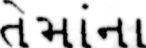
તેમાંના
